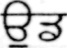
ਉਡ
